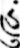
હું
